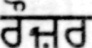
ਰੌਜ਼ਰ
